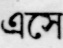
এসে
